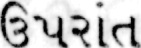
ઉપરાંત
